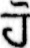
ਹੋ
